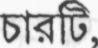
চারটি,
